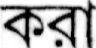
করা
